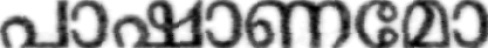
പാഷാണമോ
